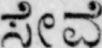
ಸೇವೆ
